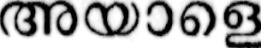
അയാളെ
